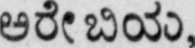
ಅರೇಬಿಯ,
